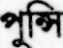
পুন্সি
